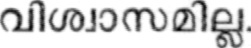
വിശ്വാസമില്ല.
